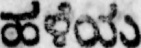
ಹಳೆಯ
